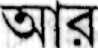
আর
